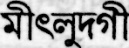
মীৎলুদগী
